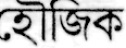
হৌজিক
